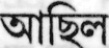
আছিল
